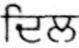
ਦਿਲ
